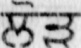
ਲੋੜ
